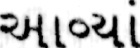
આવ્યાં
